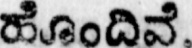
ಹೊಂದಿವೆ.
